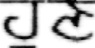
ਹੁਣ
